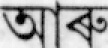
আৰু
